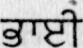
ਭਾਈ
